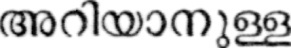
അറിയാനുള്ള
